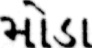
મોડા
